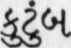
કુટુંબ
